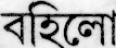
বহিলো
